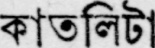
কাতলিটা
